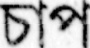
চাপ
